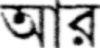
আর
